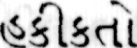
હકીકતો
